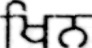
ਖਿਨ
